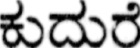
ಕುದುರೆ
